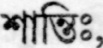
শান্তিঃ,
